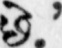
છે.'
